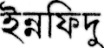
ইন্নফিদু
